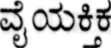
ವೈಯಕ್ತಿಕ
